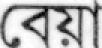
বেয়া
